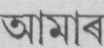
আমাৰ
